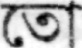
তো
